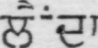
ਲੈਂਦਾ
